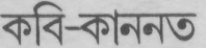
কবি-কাননত
